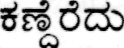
ಕಣ್ದೆರೆದು
